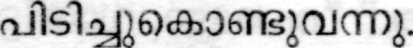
പിടിച്ചുകൊണ്ടുവന്നു.
